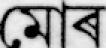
মোৰ
